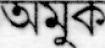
অমুক
